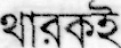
থারকই
